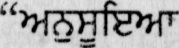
''ਅਨੁਸੂਇਆ
